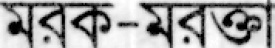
মরক-মরক্তা
